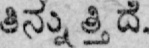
ತಿನ್ನುತ್ತಿದೆ.
